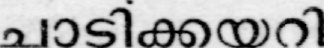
ചാടിക്കയറി
